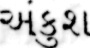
અંકુશ
